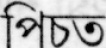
পিচত
